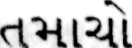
તમાચો
